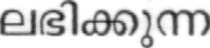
ലഭിക്കുന്ന
